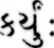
કર્યું:
